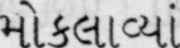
મોકલાવ્યાં
